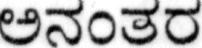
ಅನಂತರ
